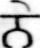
ਨੇ
